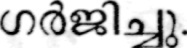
ഗര്‍ജിച്ചു.
